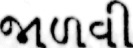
જાળવી
